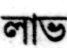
লাভ
